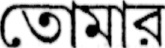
তোমার
